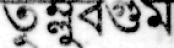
তুম্লুবগুম
